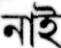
নাই
